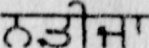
ਨਤੀਜਾ
